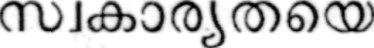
സ്വകാര്യതയെ
